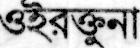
ওইরক্তুনা
